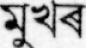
মুখৰ
